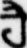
ਹੈ
